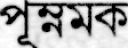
পূম্নমক
